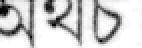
অথচ
